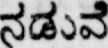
ನಡುವೆ
